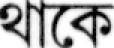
থাকে
